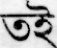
তই
